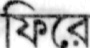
ফিরে
